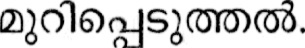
മുറിപ്പെടുത്തല്‍.
